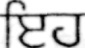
ਇਹ
